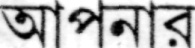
আপনার
